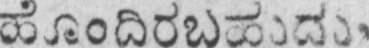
ಹೊಂದಿರಬಹುದು.
